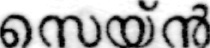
സെയ്ന്‍
